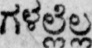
ಗಳಲ್ಲೆಲ್ಲ
